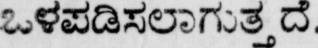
ಒಳಪಡಿಸಲಾಗುತ್ತದೆ.
